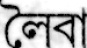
লৈবা
